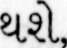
થશે,
